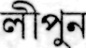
লীপুন
